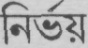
নিৰ্ভয়
